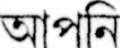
আপনি
